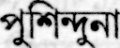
পুশিন্দুনা
